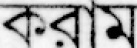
করাম
